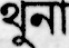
থুনা
